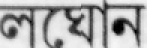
লঘোন
